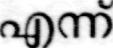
എന്ന്
